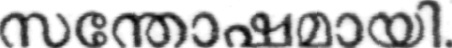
സന്തോഷമായി.
